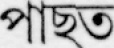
পাছত
